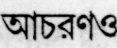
আচরণও
